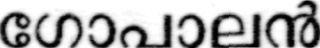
ഗോപാലന്‍
